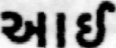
આઈ
